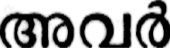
അവര്‍
